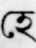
হে
